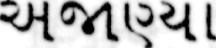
અજાણ્યા
